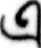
এ
